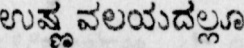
ಉಷ್ಣವಲಯದಲ್ಲೂ
